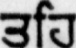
ਤਹਿ
